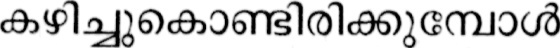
കഴിച്ചുകൊണ്ടിരിക്കുമ്പോള്‍
